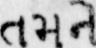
તમને
